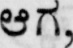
ಆಗ,
